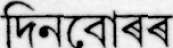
দিনবোৰৰ
